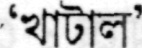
‘খাটাল’
